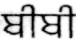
ਬੀਬੀ
